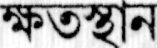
ক্ষতস্থান
